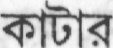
কাটার
